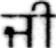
ਜੀ
